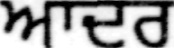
ਆਦਰ
